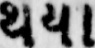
થયા
